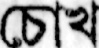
চোখ
